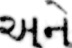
અને
